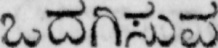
ಒದಗಿಸುವ
